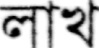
লাখ
